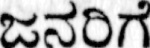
ಜನರಿಗೆ
